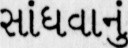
સાંધવાનું
